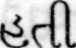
હતી
